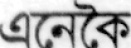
এনেকৈ
